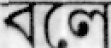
বলে
